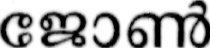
ജോണ്‍
